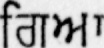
ਗਿਆ
